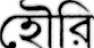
হৌরি
